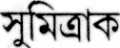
সুমিত্রাক
